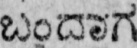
ಬಂದಾಗ
